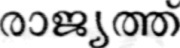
രാജ്യത്ത്
